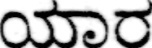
ಯಾರ
